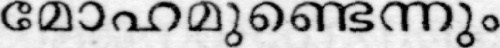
മോഹമുണ്ടെന്നും
